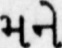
મને
